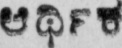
ಆರ್ಥಿಕ
